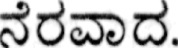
ನೆರವಾದ.
